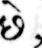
છે,
